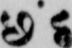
છંદ
